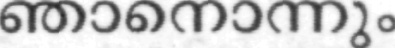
ഞാനൊന്നും
